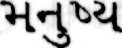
મનુષ્ય
